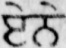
ਏਨੇ
